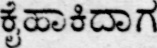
ಕೈಹಾಕಿದಾಗ
